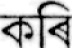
কৰি
